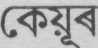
কেয়ূৰ
